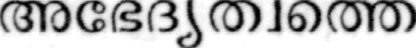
അഭേദ്യത്വത്തെ
